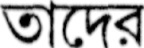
তাদের
